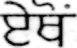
ਏਥੋਂ
